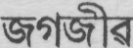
জগজীৱ
